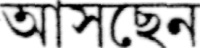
আসছেন
